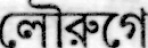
লৌরুগে
